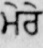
ਮੇਰੇ
